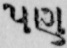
પણ
